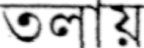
তলায়
